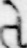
તે
